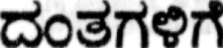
ದಂತಗಳಿಗೆ
